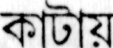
কাটায়
